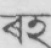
ৰহ
